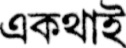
একথাই
